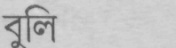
বুলি
